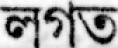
লগত
